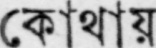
কোথায়
